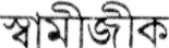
স্বামীজীক
